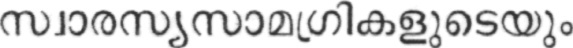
സ്വാരസ്യസാമഗ്രികളുടെയും
